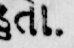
હતો.
